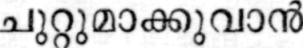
ചുറ്റുമാക്കുവാന്‍
